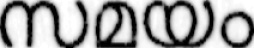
സമയം
